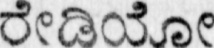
ರೇಡಿಯೋ
